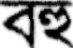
বহু
